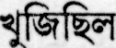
খুজিছিল
